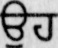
ਉਹ
